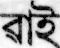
ৱাই
